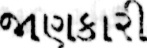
જાણકારી
